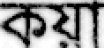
কয়া
